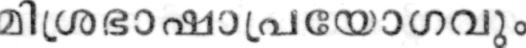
മിശ്രഭാഷാപ്രയോഗവും
